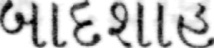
બાદશાહ
